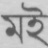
মই
